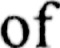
of
